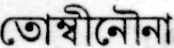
তোম্বীনৌনা
